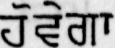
ਹੋਵੇਗਾ
